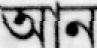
আন
